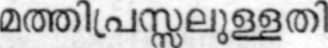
മത്തിപ്രസ്സലുള്ളതി
